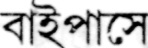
বাইপাসে
